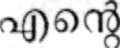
എന്റെ
